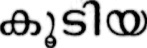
കൂടിയ
